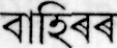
বাহিৰৰ
